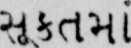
સૂક્તમાં
